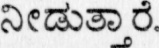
ನೀಡುತ್ತಾರೆ.
